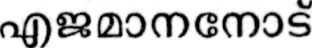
എജമാനനോട്
